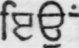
ਇਉਂ
